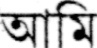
আমি
